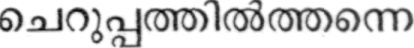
ചെറുപ്പത്തില്‍ത്തന്നെ
